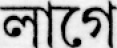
লাগে
